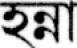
হন্না
